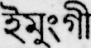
ইমুংগী
